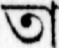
তা
